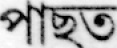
পাছত
